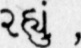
રહ્યું,
